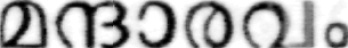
മന്ദാരവം
